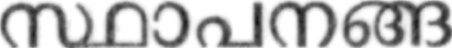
സ്ഥാപനങ്ങ
